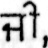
ਜੀ,
